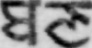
ਬਣ
